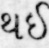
થઈ
